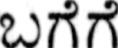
ಬಗೆಗೆ
